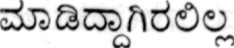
ಮಾಡಿದ್ದಾಗಿರಲಿಲ್ಲ
